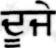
ਦੂਜੇ
